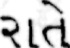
રાતે
